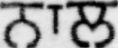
ਨਾਲ
